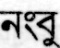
নংবু
